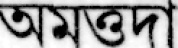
অমত্তদা
